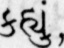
કહ્યું,
